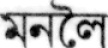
মনলৈ
